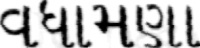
વધામણા
